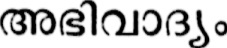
അഭിവാദ്യം
